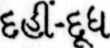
દહીં-દૂધ
